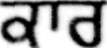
ਕਾਰ
